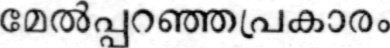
മേല്‍പ്പറഞ്ഞപ്രകാരം
